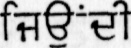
ਜਿਉਂਦੀ
